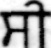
ਸੀ
